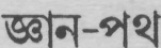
জ্ঞান-পথ
